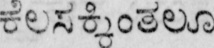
ಕೆಲಸಕ್ಕಿಂತಲೂ
